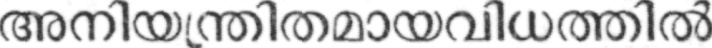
അനിയന്ത്രിതമായവിധത്തില്‍
